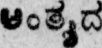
ಅಂತ್ಯದ
